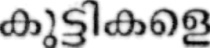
കുട്ടികളെ
